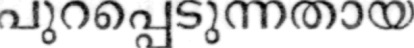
പുറപ്പെടുന്നതായ
